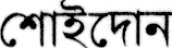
লম্মাংদোংগী
